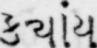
ક્યાંય
